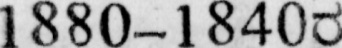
1880-1840ರ
